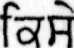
ਕਿਸੇ
